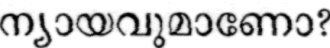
ന്യായവുമാണോ?
